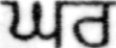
ਘਰ
